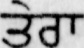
ਤੇਰਾ
